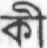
কী
